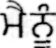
ਮੈਨੂੰ
